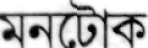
মনটোক
